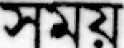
সময়
